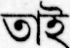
তাই
